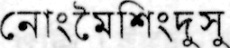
নোংমৈশিংদুসু
